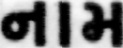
નામ
